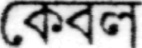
কেবল
